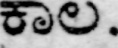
ಕಾಲ.
